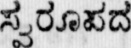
ಸ್ವರೂಪದ
